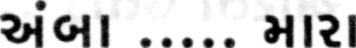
અંબ......મારા
